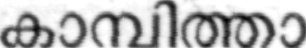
കാമ്പിത്താ
